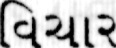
વિચાર
